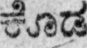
ಕೊಡ
